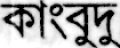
কাংবুদু
